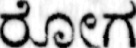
ರೋಗ
